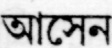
আসেন
